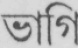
ভাগি
